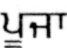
ਪੂਜਾ
